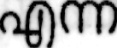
എന്ന
